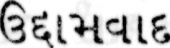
ઉદ્દામવાદ
